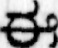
ಈ
